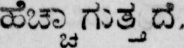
ಹೆಚ್ಚಾಗುತ್ತದೆ.
